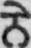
ਨੇ
